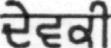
ਦੇਵਕੀ
